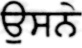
ਉਸਨੇ
